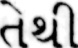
તેથી
